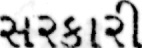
સરકારી
